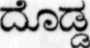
ದೊಡ್ಡ
